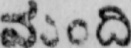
ಮಂದಿ
